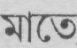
মাতে
